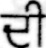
ਦੀ
